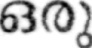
ഒരു
